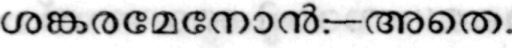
ശങ്കരമേനോന്‍:-അതെ.
